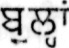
ਬੁਲ੍ਹਾਂ
